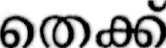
തെക്ക്
